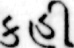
કહી
